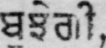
ਬੁਝੇਗੀ,
